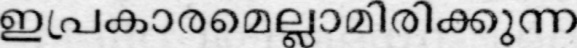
ഇപ്രകാരമെല്ലാമിരിക്കുന്ന
